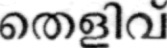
തെളിവ്
